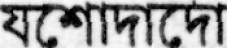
যশোদাদো
